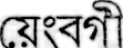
য়েংবগী
